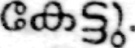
കേട്ടു.
